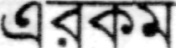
এরকম
